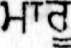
ਮਾਰੂ
